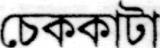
চেককাটা
